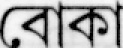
বোকা
